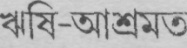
ঋষি-আশ্ৰমত
